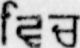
ਵਿਚ
